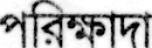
পরিক্ষাদা
